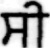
ਸੀ
